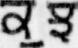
ਕੁਝ
